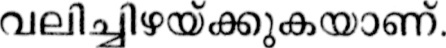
വലിച്ചിഴയ്ക്കുകയാണ്.
